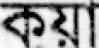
কয়া
